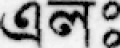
এলঃ
